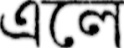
এলে
